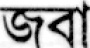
জবা
